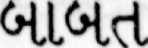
બાબત
